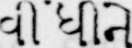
વીંધીને
